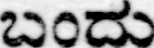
ಬಂದು
